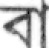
বা
